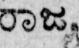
ರಾಜ್ಯ
